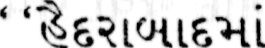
"હૈદરાબાદમાં
